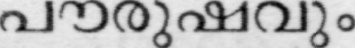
പൌരുഷവും
